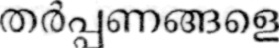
തര്‍പ്പണങ്ങളെ
